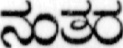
ನಂತರ
